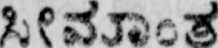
ಸೀಮಾಂತ
